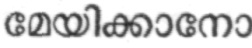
മേയിക്കാനോ
